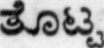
ತೊಟ್ಟ
